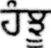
ਹੰਝੂ
